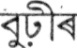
বুঢ়ীৰ
